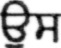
ਉਸ
